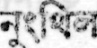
নুংথিল
